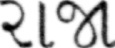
રાજા
